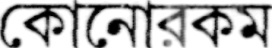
কোনোরকম
